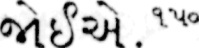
જોઈએ.૧૫૦
